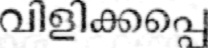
വിളിക്കപ്പെ
